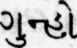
ગુન્હો
